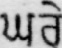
ਘਰੇ
